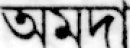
অমদা
